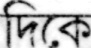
দিকে
